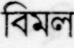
বিমল
